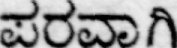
ಪರವಾಗಿ
